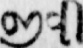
જીવી
